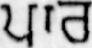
ਪਾਰ
